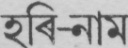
হৰি-নাম
